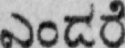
ಎಂದರೆ
